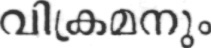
വിക്രമനും
